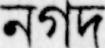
নগদ
